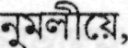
নুমলীয়ে,
